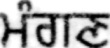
ਮੰਗਣ
